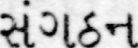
સંગઠન
